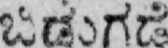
ಬಿಡುಗಡೆ
